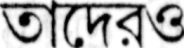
তাদেরও
